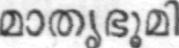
മാതൃഭൂമി
